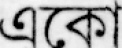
একো
